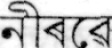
নীৰৱে
